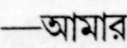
–আমার
